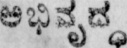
ಅಭಿವೃದ್ಧ
